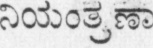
ನಿಯಂತ್ರಣಾ
